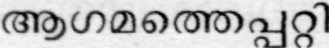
ആഗമത്തെപ്പറ്റി
